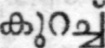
കുറച്ച്
